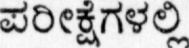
ಪರೀಕ್ಷೆಗಳಲ್ಲಿ
